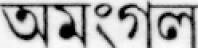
অমংগল
